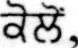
ਕੋਲੋਂ,
